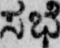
ಸಭೆ
